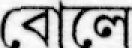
বোলে
